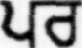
ਪਰ
